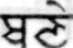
ਬਣੇ
